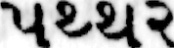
પથ્થર
